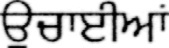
ਉਚਾਈਆਂ
